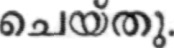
ചെയ്തു.
